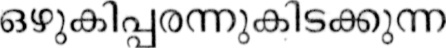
ഒഴുകിപ്പരന്നുകിടക്കുന്ന
